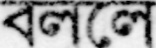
বললে
